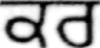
ਕਰ
